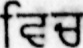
ਵਿਚ
